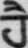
ਹੈ
